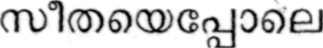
സീതയെപ്പോലെ
